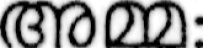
അമ്മ:
